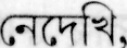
নেদেখি,
